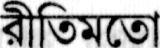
রীতিমতো
